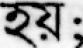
হয়;
